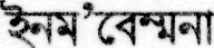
ইনম’বেম্মনা
